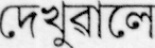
দেখুৱালে
